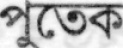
পুতেক
